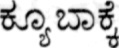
ಕ್ಯೂಬಾಕ್ಕೆ
